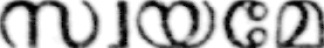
സ്വയമേ
